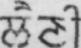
ਲੈਣੀ
